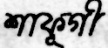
শাফূগী
